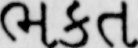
ભક્ત
